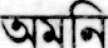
অমনি
